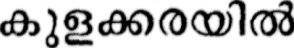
കുളക്കരയില്‍
